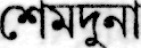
শেমদুনা
